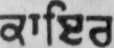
ਕਾਇਰ
